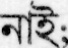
নাই;
